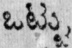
ಒಟ್ಟು
